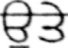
ਉਤੇ
